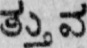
ತ್ತುವ
